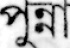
পুন্না
